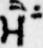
ਮੈਂ
